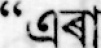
"এৰা
